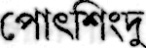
পোৎশিংদু
